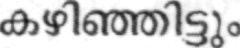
കഴിഞ്ഞിട്ടും
